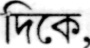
দিকে,
